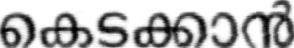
കെടക്കാന്‍
